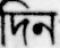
দিন
